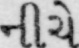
નીચે
